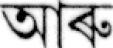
আৰু
